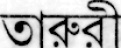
তারুরী
